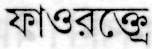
ফাওরক্ত্রে
